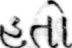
હતો
